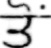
ਤੋਂ
